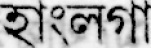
হাংলগা
